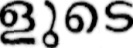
ളുടെ
